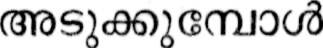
അടുക്കുമ്പോള്‍
